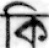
কি
